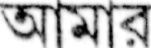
আমার
